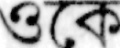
ওকে
